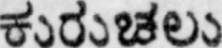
ಕುರುಚಲು
